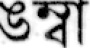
ঙম্বা
